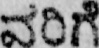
ವರಿಗೆ
